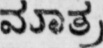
ಮಾತ್ರ
